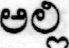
ಅಲ್ಲಿ
